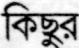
কিছুর
